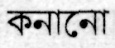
কনানো
